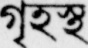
গৃহস্থ
